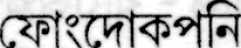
ফোংদোকপনি
